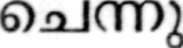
ചെന്നു
